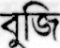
বুজি
